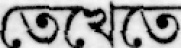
তেখেতে
